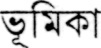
ভূমিকা
